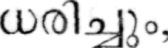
ധരിച്ചും,
